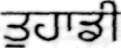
ਤੁਹਾਡੀ
